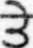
ਤੇ
